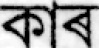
কাৰ
